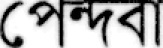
পেন্দবা
